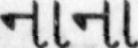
નાના
